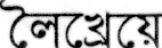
লৈখ্রেয়ে
